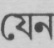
যেন
